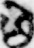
છે
